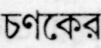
চণকের
